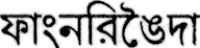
ফাংনরিঙৈদা
